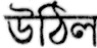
উঠিল
